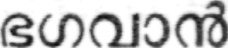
ഭഗവാന്‍
